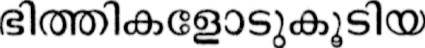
ഭിത്തികളോടുകൂടിയ
